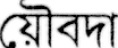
য়ৌবদা
